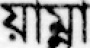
য়াম্না
